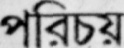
পরিচয়
